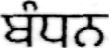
ਬੰਧਨ
